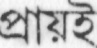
প্রায়ই
